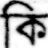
কি
